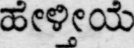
ಹೇಳ್ತೀಯೆ
